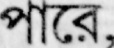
পারে,
